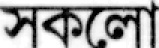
সকলো
